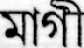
মাগী
